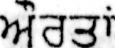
ਔਰਤਾਂ
